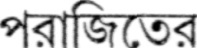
পরাজিতের
